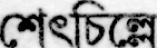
শেৎচিল্লে
